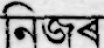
নিজৰ
